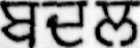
ਬਦਲ
